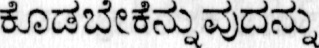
ಕೊಡಬೇಕೆನ್ನುವುದನ್ನು
